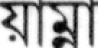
য়াম্না
